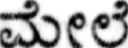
ಮೇಲೆ
